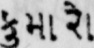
કુમારો
